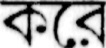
করে
